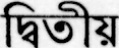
দ্বিতীয়
